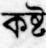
কষ্ট
